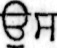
ਉਸ
